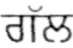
ਗੱਲ
